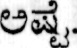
ಅಷ್ಟೆ.
